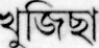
খুজিছা
